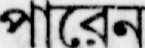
পারেন
